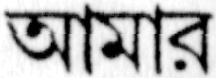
আমার
